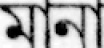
মানা
